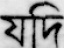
যদি
